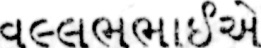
વલ્લભભાઈએ
